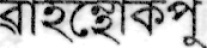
ৱাহন্থোকপু
